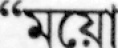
"ময়ো
